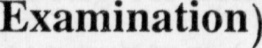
Examination)
